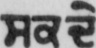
ਸਕਦੇ
